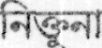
নিক্তুনা
